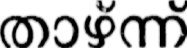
താഴ്ന്ന്
